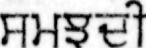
ਸਮਝਦੀ
